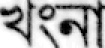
খংনা
